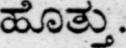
ಹೊತ್ತು.
